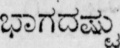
ಭಾಗದಷ್ಟು
